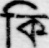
কি
